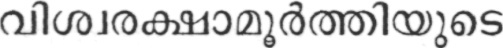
വിശ്വരക്ഷാമൂര്‍ത്തിയുടെ
